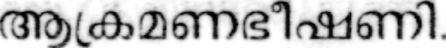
ആക്രമണഭീഷണി.
